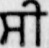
ਸੀ
